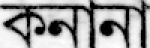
কনানা
